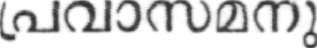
പ്രവാസമനു
